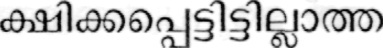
ക്ഷിക്കപ്പെട്ടിട്ടില്ലാത്ത
